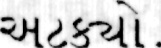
અટક્યો.
